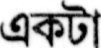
একটা
